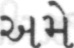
અમે
